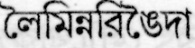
লৈমিন্নরিঙৈদা
